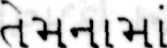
તેમનામાં
